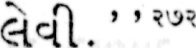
લેવી."૨૭૨
